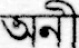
অনী
